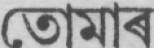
তোমাৰ
